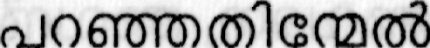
പറഞ്ഞതിന്മേല്‍
